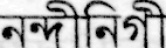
নন্দীনিগী
